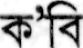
ক'বি
